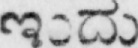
ಇಂದು
